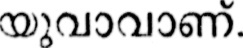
യുവാവാണ്.
